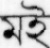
মই
